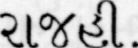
રાજહી.
